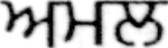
ਅਮਲ
